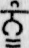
ਨੂੰ
